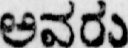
ಅವರು
